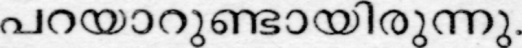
പറയാറുണ്ടായിരുന്നു.
